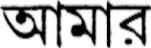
আমার
